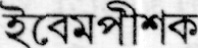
ইবেমপীশক
